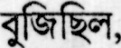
বুজিছিল,
